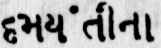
દમયંતીના
